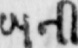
બની
